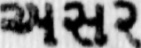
અસર
